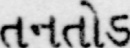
તનતોડ
